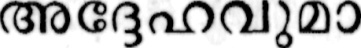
അദ്ദേഹവുമാ
